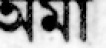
অমা
